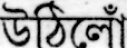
উঠিলোঁ
